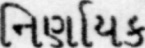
નિર્ણાયક
